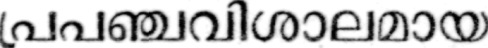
പ്രപഞ്ചവിശാലമായ
